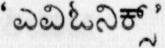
‘ಎವಿಓನಿಕ್ಸ್’
